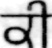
ਕੀ
